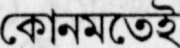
কোনমতেই
